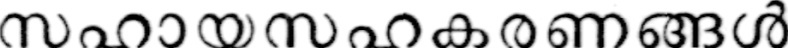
സഹായസഹകരണങ്ങള്‍
